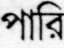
পারি
